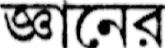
জ্ঞানের
